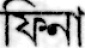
ফিনা
